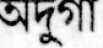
অদুগা
